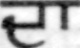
ਦਾ
